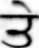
ਤੇ
